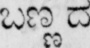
ಬಣ್ಣದ
